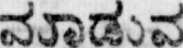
ಮಾಡುವ
